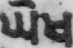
ਘੋਖ
